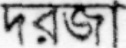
দরজা
